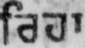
ਰਿਹਾ
